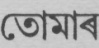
তোমাৰ
